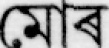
মোৰ
